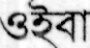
ওইবা
